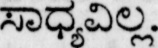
ಸಾಧ್ಯವಿಲ್ಲ.
